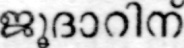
ജൂദാറിന്
